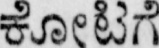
ಕೋಟಿಗೆ
